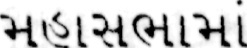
મહાસભામાં
